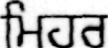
ਮਿਹਰ
